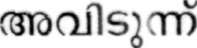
അവിടുന്ന്
